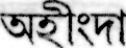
অহীংদা
